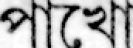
পাখো
